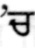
'ਚ
